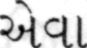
એવા
